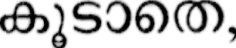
കൂടാതെ,
